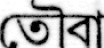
তৌবা
